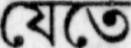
যেতে
